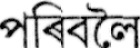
পৰিবলৈ
